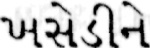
ખસેડીને
